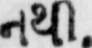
નથી
